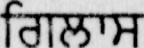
ਗਿਲਾਸ
